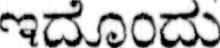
ಇದೊಂದು
